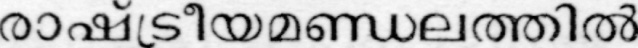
രാഷ്ട്രീയമണ്ഡലത്തില്‍
